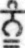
ਨੂੰ
